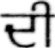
ਦੀ
